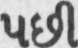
પછી
